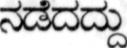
ನಡೆದದ್ದು
